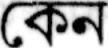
কেন
